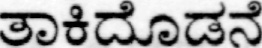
ತಾಕಿದೊಡನೆ
